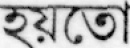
হয়তো
